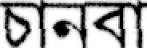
চানবা
